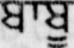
ਬਾਬੂ
